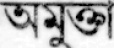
অমুক্তা
